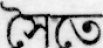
সৈতে
